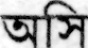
অসি
